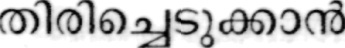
തിരിച്ചെടുക്കാന്‍
